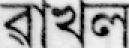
ৱাখল
